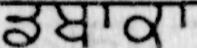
ਡਬਾਕਾ
